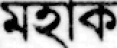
মহাক
